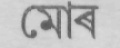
মোৰ
